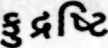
કુદ્રષ્ટિ
